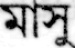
মাসু
